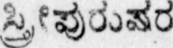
ಸ್ತ್ರೀಪುರುಷರ
